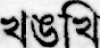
খঙখি
